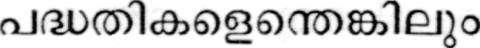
പദ്ധതികളെന്തെങ്കിലും
